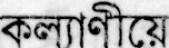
কল্যাণীয়ে
